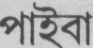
পাইবা
